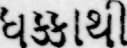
ધક્કાથી
